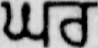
ਘਰ
